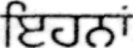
ਇਹਨਾਂ
